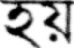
হয়
